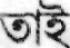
তাই
